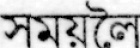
সময়লৈ
